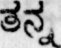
ತನ್ನ
